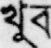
খুব
